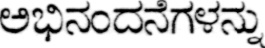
ಅಭಿನಂದನೆಗಳನ್ನು
